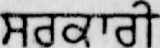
ਸਰਕਾਰੀ
